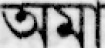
অমা
